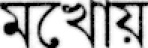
মখোয়
